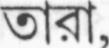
তারা,
